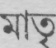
মাতৃ
